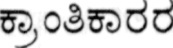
ಕ್ರಾಂತಿಕಾರರ
